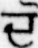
ਦੋ
